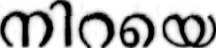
നിറയെ
